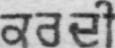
ਕਰਦੀ
